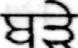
ਬੜੇ
